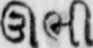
ઊભી
